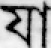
যা
